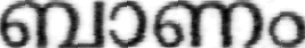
ബാണം
